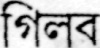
গিলব
